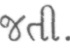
જતી.
